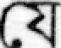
যে
